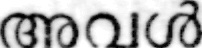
അവള്‍
